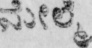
ಮೇಲ್ಮೆ
